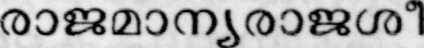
രാജമാന്യരാജശീ
